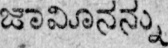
ಜಾಮೀನನ್ನು
